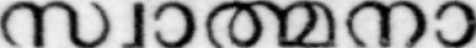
സ്വാത്മനാ
